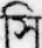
সি
